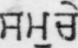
ਸਮੁਚੇ
